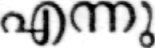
എന്നു
